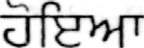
ਹੋਇਆ
